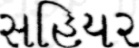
સહિયર
